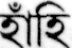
হাঁহি
